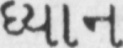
ધ્યાન
